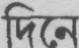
দিনে
